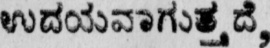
ಉದಯವಾಗುತ್ತದೆ,
